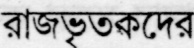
রাজভৃতকদের
